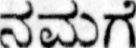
ನಮಗೆ
